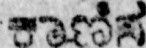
ಕಾಣಿಸ
